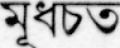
মূধচত
